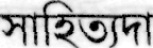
সাহিত্যদা
